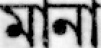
মানা
